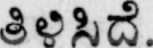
ತಿಳಿಸಿದೆ.
